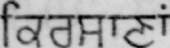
ਕਿਰਸਾਣਾਂ
